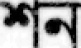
শন
